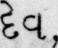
દેવ,
